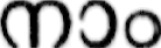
നാം
